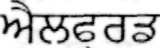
ਐਲਫ਼ਰਡ
